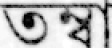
তম্বা
